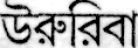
উরুরিবা
